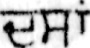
ਦਸਾਂ
